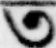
ত
